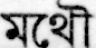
মথৌ
